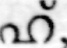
ഹ്,
